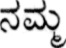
ನಮ್ಮ
